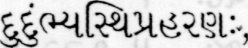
દુદુંભ્યસ્થિપ્રહરણઃ,
